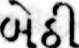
બેઠી
